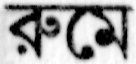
রুমে
